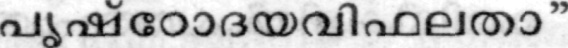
പൃഷ്ഠോദയവിഫലതാ"
